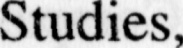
Studies,
